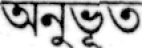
অনুভূত
